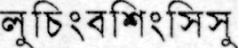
লুচিংবশিংসিসু
